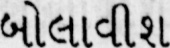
બોલાવીશ
